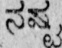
ನಷ್ಟ
